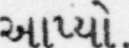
આપ્યો.
